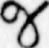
જ
